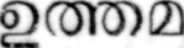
ഉത്തമ
